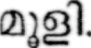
മൂളി.
